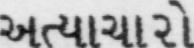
અત્યાચારો
